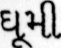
ઘૂમી
